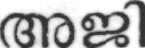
അജി
